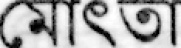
মোৎতা
